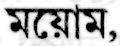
ময়োম,
